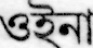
ওইনা
